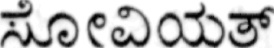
ಸೋವಿಯತ್
